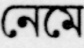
নেমে
